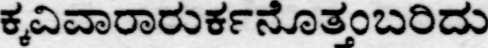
ಕ್ಕವಿವಾರಾರುರ್ಕನೊತ್ತ೦ಬರಿದು
